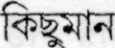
কিছুমান
